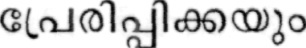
പ്രേരിപ്പിക്കയും
